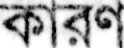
কারণ
